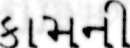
કામની
